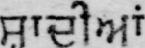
ਸ਼ਾਦੀਆਂ
